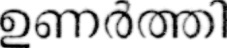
ഉണര്‍ത്തി
